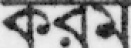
করম
